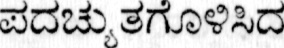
ಪದಚ್ಯುತಗೊಳಿಸಿದ
